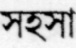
সহসা
